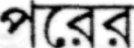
পরের
